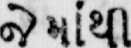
જેમાંથી
